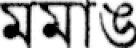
মমাঙ
